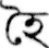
হৈ
